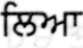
ਲਿਆ
